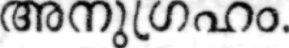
അനുഗ്രഹം.
